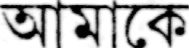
আমাকে
